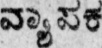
ವ್ಯಾಪಕ
